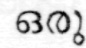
ഒരു
